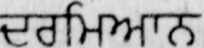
ਦਰਮਿਆਨ
